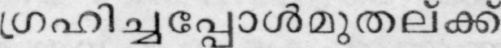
ഗ്രഹിച്ചപ്പോള്‍മുതല്ക്ക്
